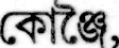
কোঞ্জৈ,
